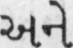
અને
